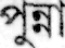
পুন্না
